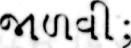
જાળવી;
